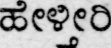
ಹೇಳ್ತೀರಿ
